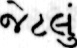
જેટલું
